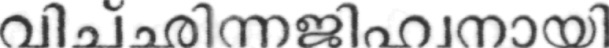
വിച്ഛിന്നജിഹ്വനായി
